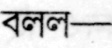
বলল–
